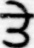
ਤੇ
